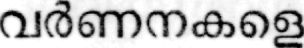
വര്‍ണനകളെ
